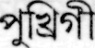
পুখ্রিগী
